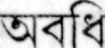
অবধি
